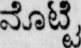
ಮೊಟ್ಟೆ
